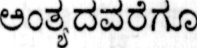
ಅಂತ್ಯದವರೆಗೂ
